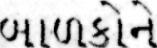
બાળકોને
